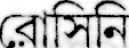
রোসিনি
